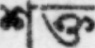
শক্ত
